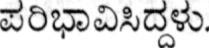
ಪರಿಭಾವಿಸಿದ್ದಳು.
